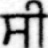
ਸੀ
